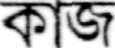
কাজ
